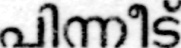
പിന്നീട്
